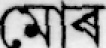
মোৰ
